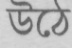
উঠে
